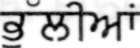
ਭੁੱਲੀਆਂ
